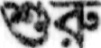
শুরু
